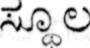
ಸ್ಥೂಲ
